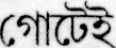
গোটেই
